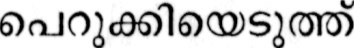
പെറുക്കിയെടുത്ത്
